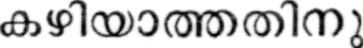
കഴിയാത്തതിനു
